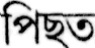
পিছত
